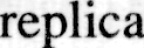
replica
